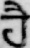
ਹੈ
